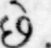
છે.
